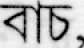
বাচ,
